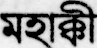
মহাক্কী
